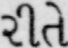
રીતે
